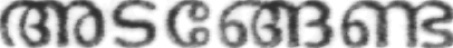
അടങ്ങേണ്ട
